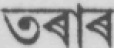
তৰাৰ
